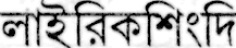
লাইরিকশিংদি
